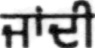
ਜਾਂਦੀ
